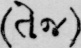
(તેજ)
